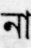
না
